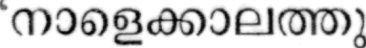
'നാളെക്കാലത്തു
